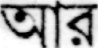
আর
